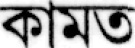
কামত
